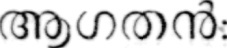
ആഗതന്‍:
